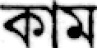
কাম
